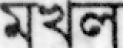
মখল
